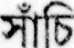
সাঁচি
